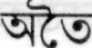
অতৈ
